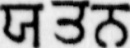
ਯਤਨ
